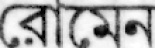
রোমেন
